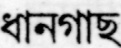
ধানগাছ
